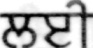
ਲਈ
